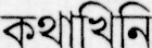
কথাখিনি
